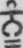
ਨੂੰ
